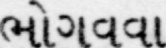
ભોગવવા
